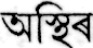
অস্থিৰ
